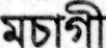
মচাগী
